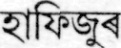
হাফিজুৰ
